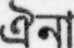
ঐনা
